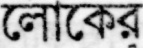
লোকের
